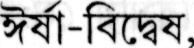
ঈর্ষা-বিদ্বেষ,
